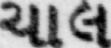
ચાલ
